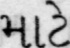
માટે
